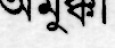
অমু্ক্কা
